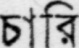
চারি
